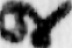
જ
